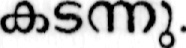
കടന്നു.
